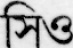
সিও
